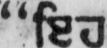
''ਇਹ
